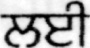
ਲਈ
